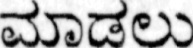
ಮಾಡಲು
